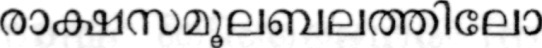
രാക്ഷസമൂലബലത്തിലോ
